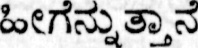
ಹೀಗೆನ್ನುತ್ತಾನೆ
